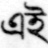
এই
